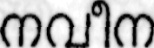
നവീന
